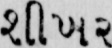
શીખર
